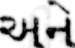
અને
